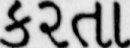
કરતા
